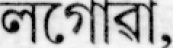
লগোৱা,
